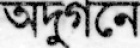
অদুগনে
